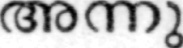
അന്നു
